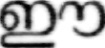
ഈ
